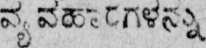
ವ್ಯವಹಾರಗಳನ್ನು
